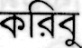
করিবু
